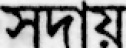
সদায়
